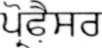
ਪ੍ਰੋਫ਼ੈਸਰ
